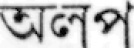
অলপ
